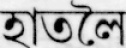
হাতলৈ
